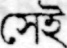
সেই
